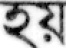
হয়
